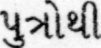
પુત્રોથી
